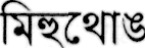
মিহুথোঙ
